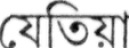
যেতিয়া
